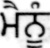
ਮੈਨੂੰ
